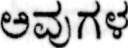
ಅವುಗಳ
